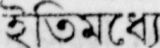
ইতিমধ্যে
